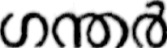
ഗന്തര്‍
